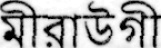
মীরাউগী
